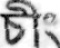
চীং
